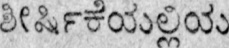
ಶೀರ್ಷಿಕೆಯಲ್ಲಿಯ
